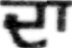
ਦਾ
